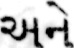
અને
